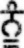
ਨੂੰ
